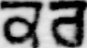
ਕਰ
